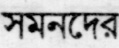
সমনদের
